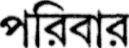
পরিবার
